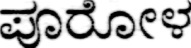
ಪೂರೋಳ
